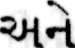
અને
